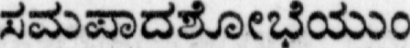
ಸಮಪಾದಶೋಭೆಯುಂ
